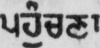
ਪਹੁੰਚਣਾ
